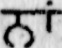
ਨਾਂ
